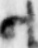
ન
